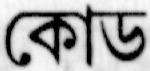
কোড
